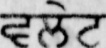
ਵਲੇਟ
